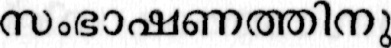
സംഭാഷണത്തിനു
